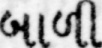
બાળી
